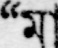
‘‘মা
